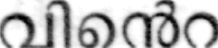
വിന്റെ
